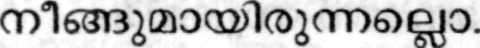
നീങ്ങുമായിരുന്നല്ലൊ.
